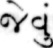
જેવું
